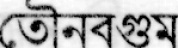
তৌনবগুম
